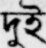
দুই
